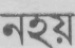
নহয়
